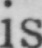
is
